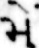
મેં
